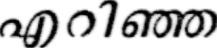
എറിഞ്ഞ
